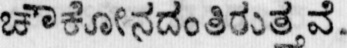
ಚೌಕೋನದಂತಿರುತ್ತವೆ.
